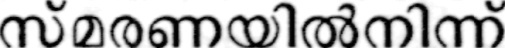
സ്മരണയില്‍നിന്ന്
